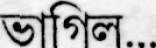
ভাগিল...
